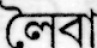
লৈবা
